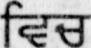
ਵਿਚ
